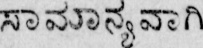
ಸಾಮಾನ್ಯವಾಗಿ
